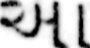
આ
